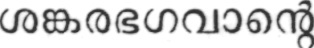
ശങ്കരഭഗവാന്റെ
